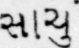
સાચું
